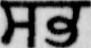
ਸਭ
